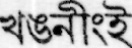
খঙনীংই
